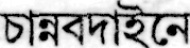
চান্নবদাইনে
